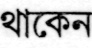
থাকেন
